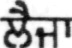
ਲੈਜਾ
